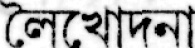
লৈখোদনা
